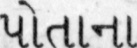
પોતાના
